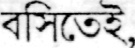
বসিতেই,
